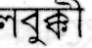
লবুক্কী
